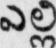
ಎಲ್ಲಿ
